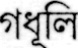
গধূলি
